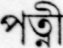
পত্নী
